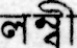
লম্বী
